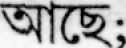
আছে;
